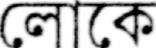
লোকে
